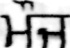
ਮੌਜ
